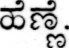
ಹೆಣ್ಣೆ.
